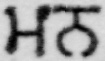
ਮਨ
